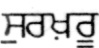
ਸੁਰਖ਼ਰੂ
